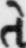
તે
